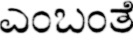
ಎಂಬಂತೆ
